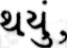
થયું,
